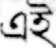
এই
